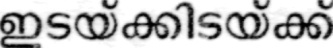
ഇടയ്ക്കിടയ്ക്ക്
